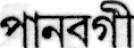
পানবগী
